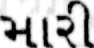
મારી
